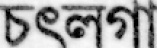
চৎলগা
